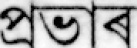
প্রভাৰ
